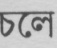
চলে
